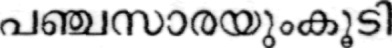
പഞ്ചസാരയുംകൂടി
